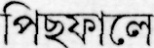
পিছফালে
